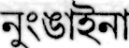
নুংঙাইনা
